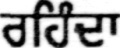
ਰਹਿੰਦਾ
